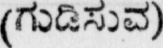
(ಗುಡಿಸುವ)
